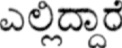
ಎಲ್ಲಿದ್ದಾರೆ
